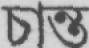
চান্ত
